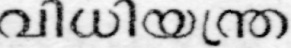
വിധിയന്ത്ര
